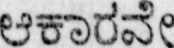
ಆಕಾರವೇ
